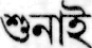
শুনাই
